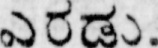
ಎರಡು.
